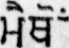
ਮੈਥੋਂ
